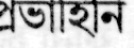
প্রভাহিনি
